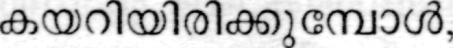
കയറിയിരിക്കുമ്പോള്‍,
